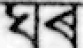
ঘৰ
